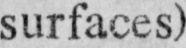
surfaces)
